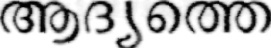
ആദ്യത്തെ
